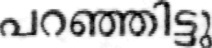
പറഞ്ഞിട്ടു
